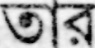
তার
